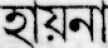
হায়না
